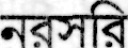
নরসরি
